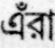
এঁরা
